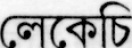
লেকেচি
